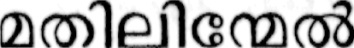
മതിലിന്മേല്‍
